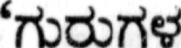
‘ಗುರುಗಳ
